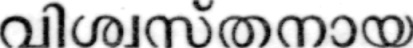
വിശ്വസ്തനായ
